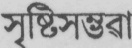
সৃষ্টিসম্ভৱা
